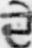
ਦੇ
